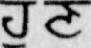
ਹੁਣ
